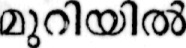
മുറിയില്‍
